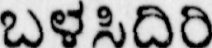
ಬಳಸಿದಿರಿ
